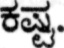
ಕಷ್ಟ.
